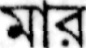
মার
